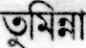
তুমিন্না
